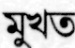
মুখত
